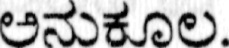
ಅನುಕೂಲ.
